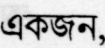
একজন,
